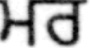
ਮਰ
